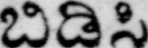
ಬಿಡಿಸಿ
